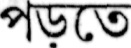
পড়তে
